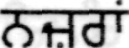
ਨਜ਼ਰਾਂ
